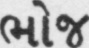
ભોજ
